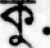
কু.
